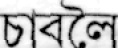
চাবলৈ
